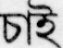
চাই
